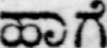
ಹಾಗೆ
